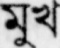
মুখ
